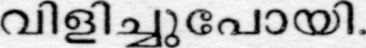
വിളിച്ചുപോയി.
